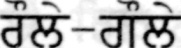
ਰੌਲੇ-ਗੌਲੇ
